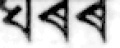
ঘৰৰ
